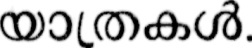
യാത്രകള്‍.
